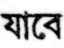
যাবে
